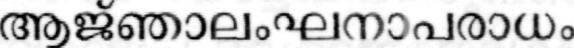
ആജ്ഞാലംഘനാപരാധം
